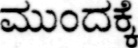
ಮುಂದಕ್ಕೆ
